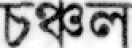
চঞ্চল
